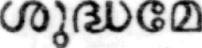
ശുദ്ധമേ
